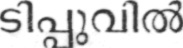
ടിപ്പുവില്‍
